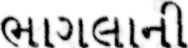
ભાગલાની
